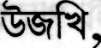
উজখি,
